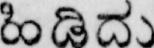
ಹಿಡಿದು
